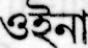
ওইনা
